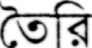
তৈরি
